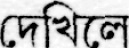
দেখিলে
